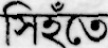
সিহঁতে
